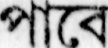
পাবে
